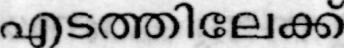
എടത്തിലേക്ക്
